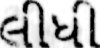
લીધી
